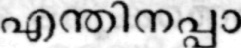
എന്തിനപ്പാ
